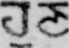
ਹੁਣ
